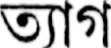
ত্যাগ
